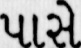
પાસે
